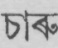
চাৰু
